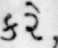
કરે,
